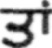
ਤਾਂ
